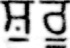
ਸ਼ੁਰੂ
